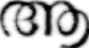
ആ
